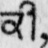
ਕੀ,
